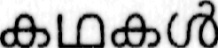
കഥകള്‍
